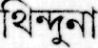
থিন্দুনা
